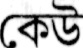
কেউ
